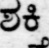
ಶಕ್ತಿ
